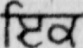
ਇਕ
